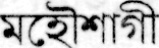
মহৌশাগী
